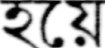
হয়ে
